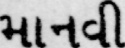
માનવી
